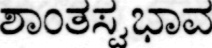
ಶಾಂತಸ್ವಭಾವ
